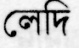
লেদি
